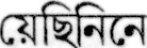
য়েছিনিনে
